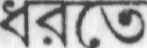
ধরতে
